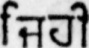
ਜਿਹੀ
